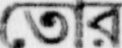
তোর
